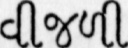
વીજળી
